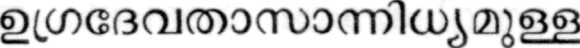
ഉഗ്രദേവതാസാന്നിധ്യമുള്ള
